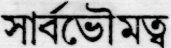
সার্বভৌমত্ব
